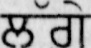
ਲੱਗੇ
